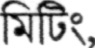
মিটিং,
